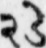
રડે
